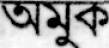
অমুক
